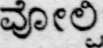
ವೋಲ್ಪಿ
